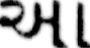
આ
